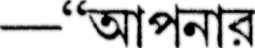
-"আপনার
